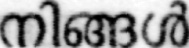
നിങ്ങള്‍
